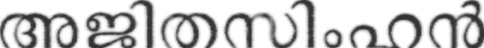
അജിതസിംഹന്‍
